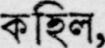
কহিল,
